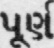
પૂર્ણ
